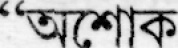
"অশোক
